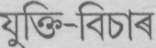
যুক্তি-বিচাৰ
